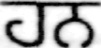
ਹਨ
